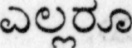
ಎಲ್ಲರೂ
